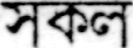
সকল
